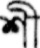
শী
